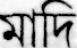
মাদি
